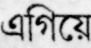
এগিয়ে
